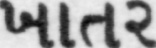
ખાતર
